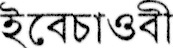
ইবেচাওবী
